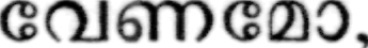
വേണമോ,
